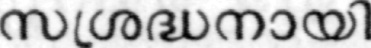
സശ്രദ്ധനായി
